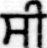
ਸੀ
